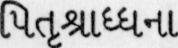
પિતૃશ્રાધ્ધના
